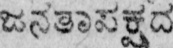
ಜನತಾಪಕ್ಷದ
